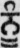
ਨੂੰ
